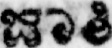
ಜಾತಿ
